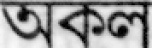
অকল
